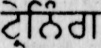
ਟ੍ਰੇਨਿੰਗ
